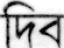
দিব
